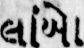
લાંબો
